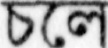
চলে
